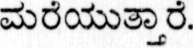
ಮರೆಯುತ್ತಾರೆ.
